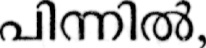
പിന്നില്‍,
